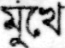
মুখে
